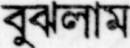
বুঝলাম
